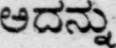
ಅದನ್ನು
